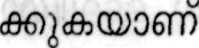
ക്കുകയാണ്
